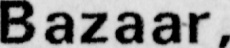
Bazaar,
